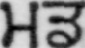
ਮਡ
